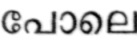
പോലെ
